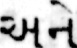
અને
